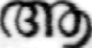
ആ
